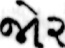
જોર
